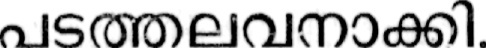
പടത്തലവനാക്കി.
